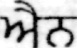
ਐਨ
